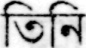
তিনি
